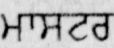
ਮਾਸਟਰ
